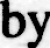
by
